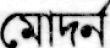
মোর্দন
